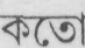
কতো
